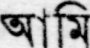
আমি
